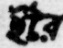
ইরৈ
